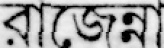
রাজেন্না
